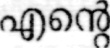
എന്റെ
